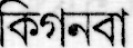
কিগনবা
